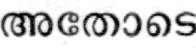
അതോടെ
